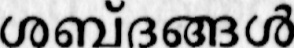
ശബ്ദങ്ങള്‍
